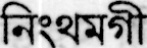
নিংথমগী
